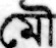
মৌ
